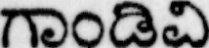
ಗಾಂಡಿವಿ
